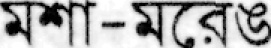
মশা-মরেঙ
